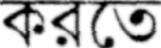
করতে
